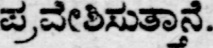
ಪ್ರವೇಶಿಸುತ್ತಾನೆ.
